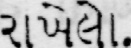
રાખેલો.
